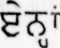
ਏਨ੍ਹਾਂ
